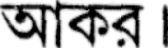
আকর।
